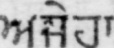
ਅਜੇਹਾ
